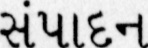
સંપાદન
